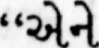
"એને
